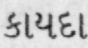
કાયદા
